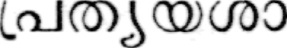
പ്രത്യയശാ
